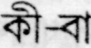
কী-বা
